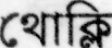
থোক্লি
